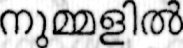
നുമ്മളില്‍
